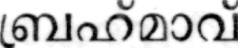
ബ്രഹ്മാവ്
